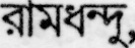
রামধন্দু,
